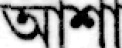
আশা
